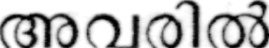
അവരില്‍
